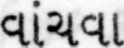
વાંચવા
